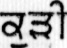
ਕੁੜੀ
